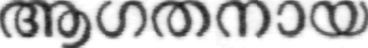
ആഗതനായ
